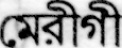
মেরীগী
